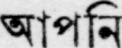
আপনি
